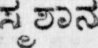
ಸ್ಮಶಾನ
